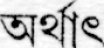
অর্থাৎ
